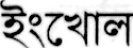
ইংখোল
